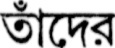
তাঁদের
